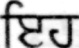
ਇਹ
